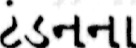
ટંડનના
